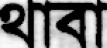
থাবা
